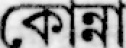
কোন্না
